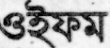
ওইফম
